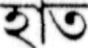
হাত
